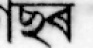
গছৰ
